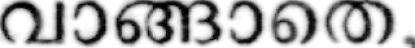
വാങ്ങാതെ,
